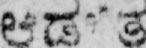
ಆಡಳಿತ
